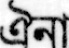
ঐনা
